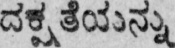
ದಕ್ಷತೆಯನ್ನು
